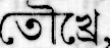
তৌখ্রে,
